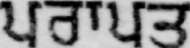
ਪਰਾਪਤ
